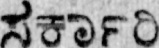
ಸರ್ಕಾರಿ
